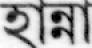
হান্না
